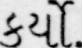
કર્યો.
